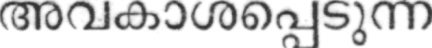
അവകാശപ്പെടുന്ന
